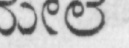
ಮೇಲೆ
